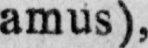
amus),
